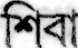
শিবা
